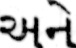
અને
